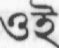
ওই
